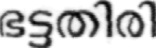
ഭട്ടതിരി
